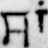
ਸਾਂ
